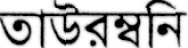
তাউরম্বনি
